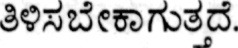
ತಿಳಿಸಬೇಕಾಗುತ್ತದೆ.
